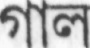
গাল
